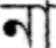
না
